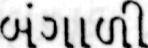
બંગાળી
